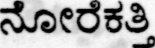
ನೋರೆಕತ್ತಿ
